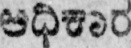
ಅಧಿಕಾರ
